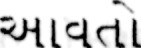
આવતો
